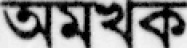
অমখক
